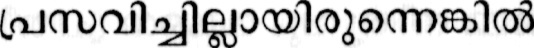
പ്രസവിച്ചില്ലായിരുന്നെങ്കില്‍
